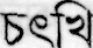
চৎখি
